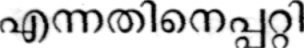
എന്നതിനെപ്പറ്റി
